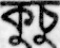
কুচু
